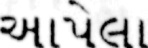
આપેલા
